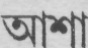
আশা
